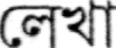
লেখা
